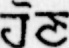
ਹੋਣ
